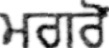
ਮਗਰੋਂ
